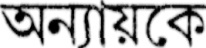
অন্যায়কে
